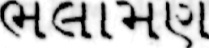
ભલામણ
